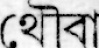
থৌবা
